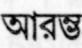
আরম্ভ
